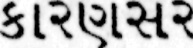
કારણસર
